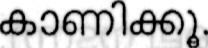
കാണിക്കൂ.
